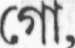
গো,
